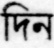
দিন
